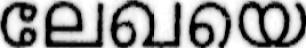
ലേഖയെ
